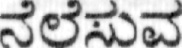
ನೆಲೆಸುವ
